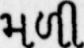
મળી
